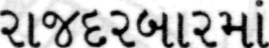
રાજદરબારમાં
